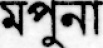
মপুনা
